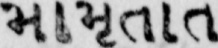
મામૃતાતા
